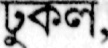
ঢুকল,
